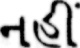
નહીં
